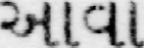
આવા
